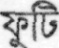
ফুটি
